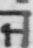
ਜੇ
